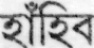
হাঁহিব
